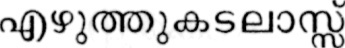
എഴുത്തുകടലാസ്സ്
